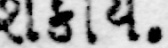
શકાય.
